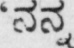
‘ನನ್ನ
